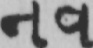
નવ
